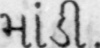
માંડી.
